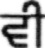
ਵੀ
